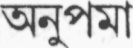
অনুপমা
